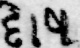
દોષ
